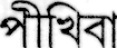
পীখিবা
